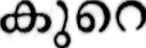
കുറെ
